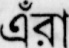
এঁরা
